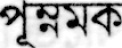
পূম্নমক
